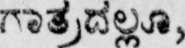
ಗಾತ್ರದಲ್ಲೂ,
